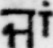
ਜਾਂ
